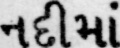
નદીમાં
